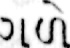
ગળે
